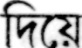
দিয়ে
